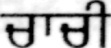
ਚਾਚੀ
